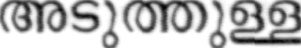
അടുത്തുള്ള
